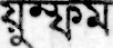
য়ুম্ফম
